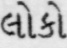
લોકો
